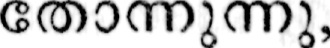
തോന്നുന്നു,
